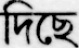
দিছে
